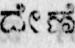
ದೇಣೆ
